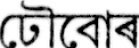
ঢৌবোৰ
